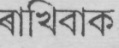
ৰাখিবাক
